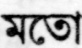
মতো
